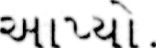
આપ્યો.
